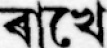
ৰাখে
